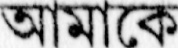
আমাকে
